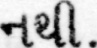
નથી.
